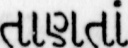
તાણતાં
